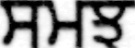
ਸਮਝ
